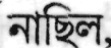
নাছিল,
